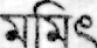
মমিৎ
